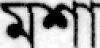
মশা
